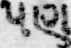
પણ
